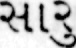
સારુ
